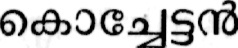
കൊച്ചേട്ടന്‍
